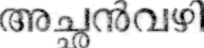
അച്ഛന്‍വഴി
